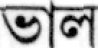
ভাল
